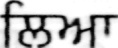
ਲਿਆ
